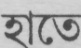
হাতে
